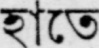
হাতে
